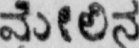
ಮೇಲಿನ
